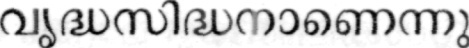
വൃദ്ധസിദ്ധനാണെന്നു
